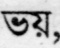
ভয়,
